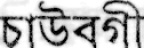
চাউবগী
